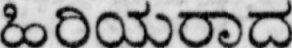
ಹಿರಿಯರಾದ
